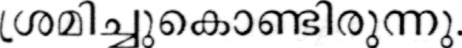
ശ്രമിച്ചുകൊണ്ടിരുന്നു.
